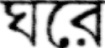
ঘরে
